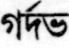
গর্দভ
